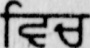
ਵਿਚ
